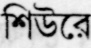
শিউরে
